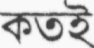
কতই
